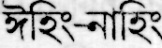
ঈহিং-নাহিং
